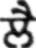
ਲੈ
